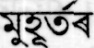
মুহূর্তৰ
